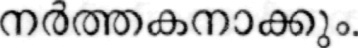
നര്‍ത്തകനാക്കും.
